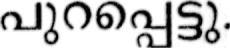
പുറപ്പെട്ടു.
